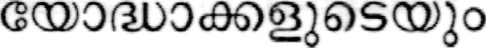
യോദ്ധാക്കളുടെയും
